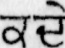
ਕਦੇ
